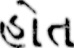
હોત
